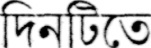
দিনটিতে
